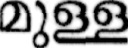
മുള്ള
